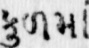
કુળમાં
